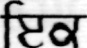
ਇਕ
